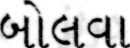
બોલવા
